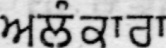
ਅਲੰਕਾਰਾ
